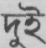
দুই
